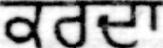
ਕਰਦਾ
